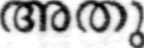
അതു
